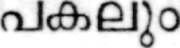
പകലും
